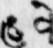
હવે
